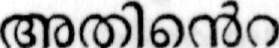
അതിന്റെ
